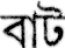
বাট
